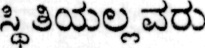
ಸ್ಥಿತಿಯಲ್ಲವರು
